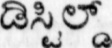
ಡಿಸ್ಟಿಲ್ಡ್
